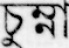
চুম্না
